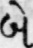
બે
